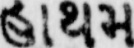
હાથમાં
